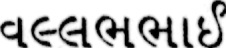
વલ્લભભાઈ
